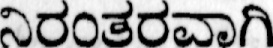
ನಿರಂತರವಾಗಿ
